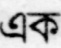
এক
